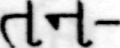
તન-
